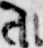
તો
